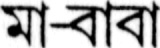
মা-বাবা
